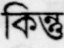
কিন্তু
